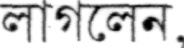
লাগলেন,
